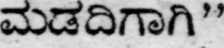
ಮಡದಿಗಾಗಿ"
